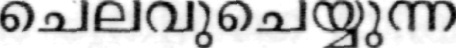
ചെലവുചെയ്യുന്ന
